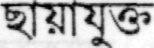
ছায়াযুক্ত
